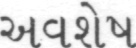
અવશેષ
